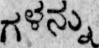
ಗಳನ್ನು
